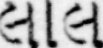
લાલ
